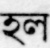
হল
